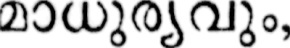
മാധുര്യവും,
